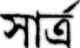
সার্ত্র
